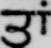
ਤਾਂ
